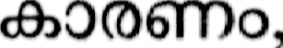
കാരണം,
